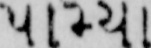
પામ્યા
